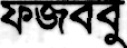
ফজববু
